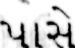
પાસે
